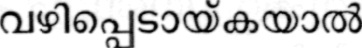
വഴിപ്പെടായ്കയാല്‍
